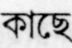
কাছে
